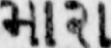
મારા
